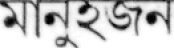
মানুহজন
